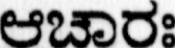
ಆಚಾರಃ
